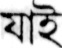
যাই
